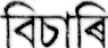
বিচাৰি
